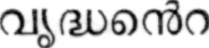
വൃദ്ധന്റെ
